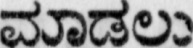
ಮಾಡಲು
